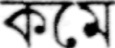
কমে
